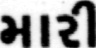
મારી
